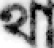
থা
